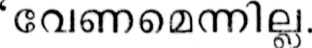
'വേണമെന്നില്ല.
